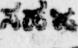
ಸಹಜ
